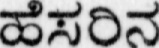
ಹೆಸರಿನ
